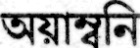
অয়াম্বনি
